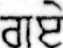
ਗਏ
